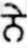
ਨੇ
